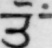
ਤੋਂ
